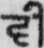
ਵੀ
